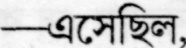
–এসেছিল,
